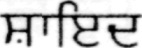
ਸ਼ਾਇਦ
